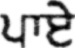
ਪਾਏ
